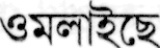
ওমলাইছে
